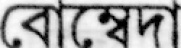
বোম্বেদা
